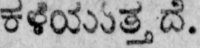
ಕಳೆಯುತ್ತದೆ.
